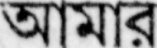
আমার
